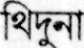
থিদুনা
